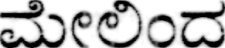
ಮೇಲಿಂದ
